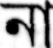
না
